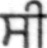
ਸੀ
